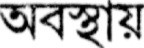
অবস্থায়
